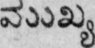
ಮುಖ್ಯ
